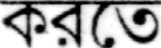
করতে
